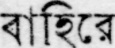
বাহিরে
